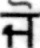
ਜੋ
